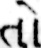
તો
